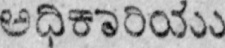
ಅಧಿಕಾರಿಯು
